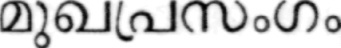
മുഖപ്രസംഗം
